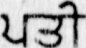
ਪਤੀ
